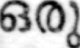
ഒരു
